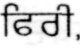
ਫਿਰੀ,
